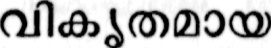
വികൃതമായ
